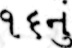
૧૬નું
